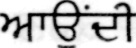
ਆਉਂਦੀ
